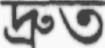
দ্রুত
